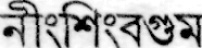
নীংশিংবগুম
